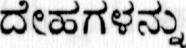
ದೇಹಗಳನ್ನು
